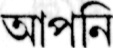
আপনি
